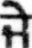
ਜੇ
